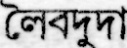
লৈবদুদা
